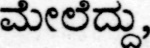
ಮೇಲೆದ್ದು,
